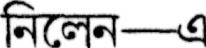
নিলেন-এ
